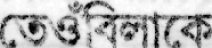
তেওঁবিলাকে
